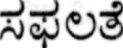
ಸಫಲತೆ
